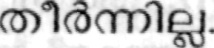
തീര്‍ന്നില്ല.
